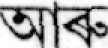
আৰু
